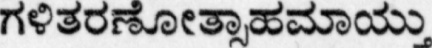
ಗಳಿತರಣೋತ್ಸಾಹಮಾಯ್ತು
